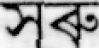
সৰু
